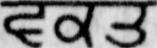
ਵਕਤ
